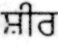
ਸ਼ੀਰ
